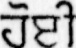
ਹੋਈ
